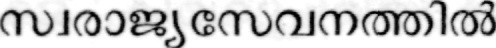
സ്വരാജ്യസേവനത്തില്‍
